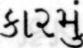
કારમું
